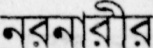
নরনারীর
